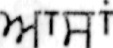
ਆਸਾਂ
